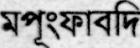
মপূংফাবদি
